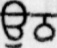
ਉਠ
